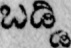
ಬಡ್ಡಿ
